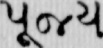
પૂજ્ય
